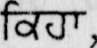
ਕਿਹਾ,
